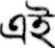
এই
